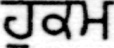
ਹੁਕਮ
